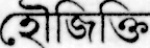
হৌজিক্তি
